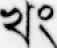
খং
